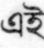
এই
